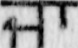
ਜਾ
